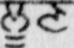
ਲੂਣ
